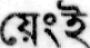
য়েংই
